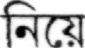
নিয়ে
